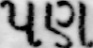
પણ
